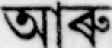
আৰু
